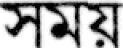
সময়
